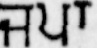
ਜਪਾ
